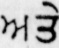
ਅਤੇ
